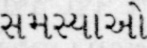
સમસ્યાઓ
